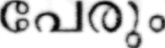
പേരും
